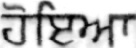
ਹੋਇਆ
